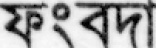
ফংবদা
